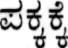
ಪಕ್ಕಕ್ಕೆ
